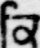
ਕਿ
